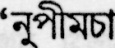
‘নুপীমচা
